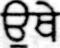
ਉਥੇ
